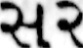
સર
